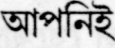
আপনিই
